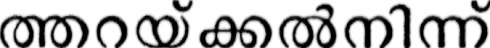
ത്തറയ്ക്കല്‍നിന്ന്
